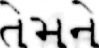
તેમને
